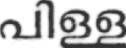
പിള്ള
